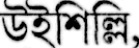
উইশিল্লি,
